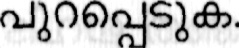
പുറപ്പെടുക.
